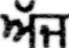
ਅੱਜ
